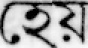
হেয়
